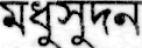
মধুসুদন
